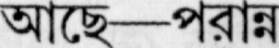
আছে-পরান্ন
